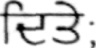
ਦਿਤੇ;
